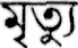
মৃত্যু
